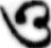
ও
